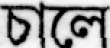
চালে
